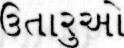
ઉતારુઓ
